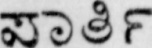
ಪಾರ್ತಿ
